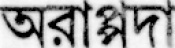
অরাপ্পদা
